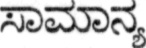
ಸಾಮಾನ್ಯ
